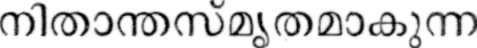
നിതാന്തസ്മൃതമാകുന്ന
